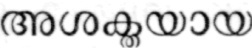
അശക്തയായ
